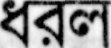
ধরল
